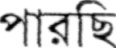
পারছি
